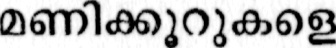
മണിക്കൂറുകളെ
